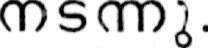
നടന്നു.
